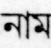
নাম
